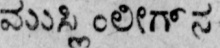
ಮುಸ್ಲಿಂಲೀಗ್‌ನ
